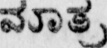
ಮಾತ್ರ
